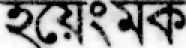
হয়েংমক
